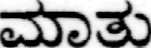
ಮಾತು
